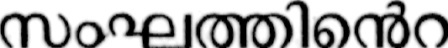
സംഘത്തിന്റെ
